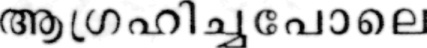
ആഗ്രഹിച്ചപോലെ
